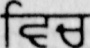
ਵਿਚ
